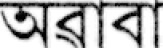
অৱাবা
